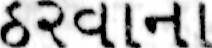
ઠરવાના
